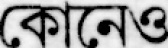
কোনেও
